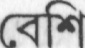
বেশি
